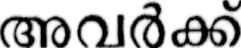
അവര്‍ക്ക്
